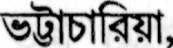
ভট্টাচারিয়া,
